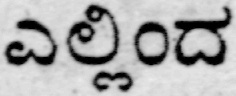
ಎಲ್ಲಿಂದ
